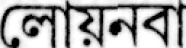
লোয়নবা
